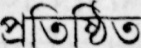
প্রতিষ্ঠিত
